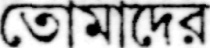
তোমাদের
